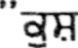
''ਕੁਸ਼
